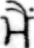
ਮੈਂ
